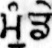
ਮੁੰਡੇ
